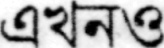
এখনও
